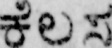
ಕೆಲಸ
